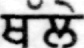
ਥੱਲੇ
